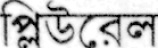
প্লিউরেল
